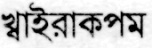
খ্বাইরাকপম
